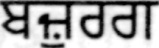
ਬਜ਼ੁਰਗ
